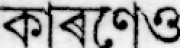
কাৰণেও
